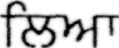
ਲਿਆ
